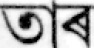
তাৰ
